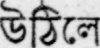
উঠিলে
